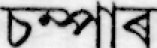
চম্পাৰ
